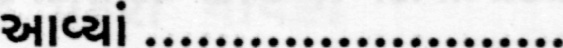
આવ્યાં............
